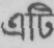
এটি
